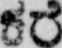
ಕರೆ
